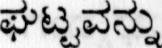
ಘಟ್ಟವನ್ನು
